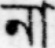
না
